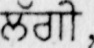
ਲੱਗੀ,
